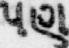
પણ
